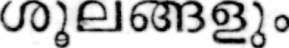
ശൂലങ്ങളും
